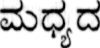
ಮಧ್ಯದ
